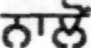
ਨਾਲੋਂ
